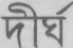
দীৰ্ঘ
